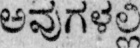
ಅವುಗಳಲ್ಲಿ
